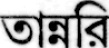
তান্নরি
